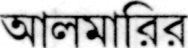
আলমারির
